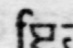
ਇਹ
